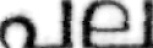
പല
